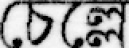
চেল্লে
